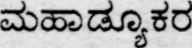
ಮಹಾಡ್ಯೂಕರ
